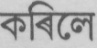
কৰিলে
